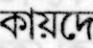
কায়দে
